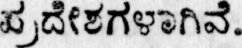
ಪ್ರದೇಶಗಳಾಗಿವೆ.
